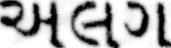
અલગ
